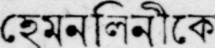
হেমনলিনীকে
